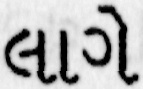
લાગે
